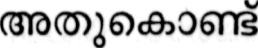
അതുകൊണ്ട്
